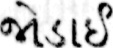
જોડાઈ
